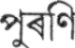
পুৰণি
